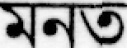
মনত
